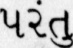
પરંતુ
